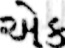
એક
